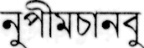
নুপীমচানবু
